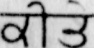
ਕੀਤੇ
